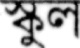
স্কুল
